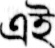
এই
